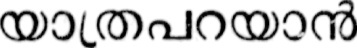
യാത്രപറയാന്‍
